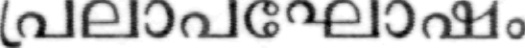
പ്രലാപഘോഷം
